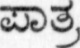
ಪಾತ್ರ
